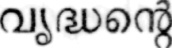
വൃദ്ധന്റെ
